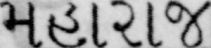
મહારાજ
